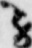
કે
